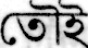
তৌই
